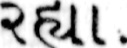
રહ્યા.
